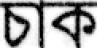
চাক
